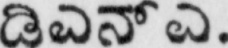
ಡಿಎನ್‌ಎ.
